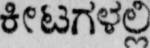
ಕೀಟಗಳಲ್ಲಿ
